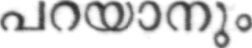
പറയാനും
